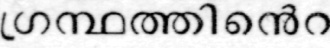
ഗ്രന്ഥത്തിന്റെ
